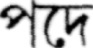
পদে
